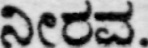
ನೀರವ.
